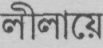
লীলায়ে
